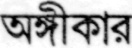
অঙ্গীকার
